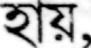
হায়,
